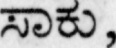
ಸಾಕು,
